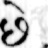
છે.
